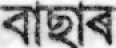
বাছাৰ
